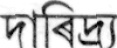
দাৰিদ্র্য
